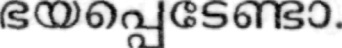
ഭയപ്പെടേണ്ടാ.
